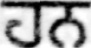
ਹਨ
